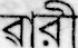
ৱারী
